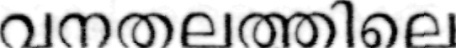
വനതലത്തിലെ
